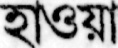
হাওয়া
